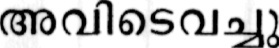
അവിടെവച്ചു
